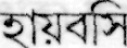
হায়বসি
